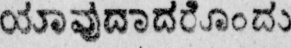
ಯಾವುದಾದರೊಂದು
